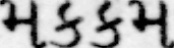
મકકમ
